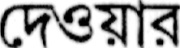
দেওয়ার
